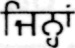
ਜਿਨ੍ਹਾਂ
